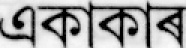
একাকাৰ
